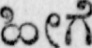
ಹೀಗೆ
